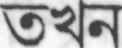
তখন
